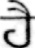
ਹੈ
